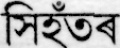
সিহঁতৰ
